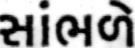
સાંભળે
